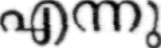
എന്നു
